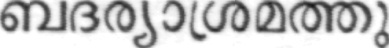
ബദര്യാശ്രമത്തു
